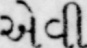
એવી
